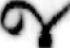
જ
